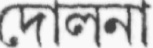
দোলনা
